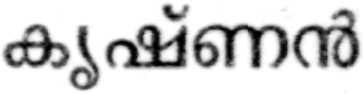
കൃഷ്ണന്‍
